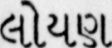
લોયણ
